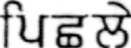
ਪਿਛਲੇ
